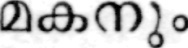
മകനും
